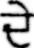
ਦੇ
